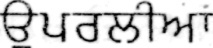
ਉਪਰਲੀਆਂ
